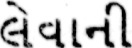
લેવાની
